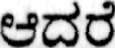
ಆದರೆ
